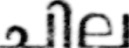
ചില
